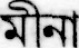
মীনা
